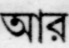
আর
